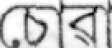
চোৱা
